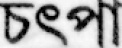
চৎপা
